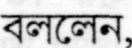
বললেন,
